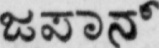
ಜಪಾನ್
